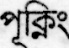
পূক্নিং
